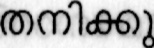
തനിക്കു
